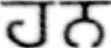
ਹਨ
